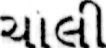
ચાલી
